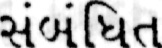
સંબંધિત
